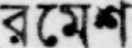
রমেশ
